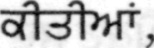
ਕੀਤੀਆਂ,
